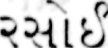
રસોઇ
